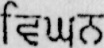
ਵਿਘਨ
